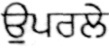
ਉਪਰਲੇ
